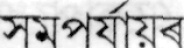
সমপৰ্যায়ৰ
